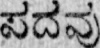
ಪದವು
